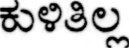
ಕುಳಿತಿಲ್ಲ
